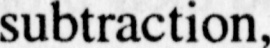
subtraction,
